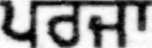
ਪਰਜਾ
